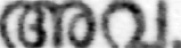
അവ.
